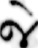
જે
